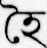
হৈ
